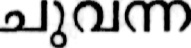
ചുവന്ന
